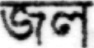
জল
